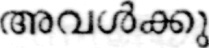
അവള്‍ക്കു
